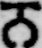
ਨ
